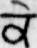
ਕੇ
